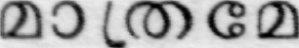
മാത്രമേ
